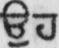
ਉਹ
